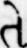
તે
